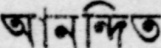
আনন্দিত
